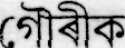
গৌৰীক
